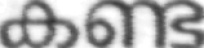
കണ്ട
